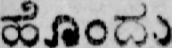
ಹೊಂದು
